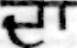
ਦਾ
